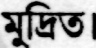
মুদ্রিত।
